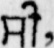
ਸੀ,
